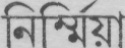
নিৰ্ম্মিয়া
